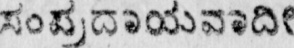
ಸಂಪ್ರದಾಯವಾದೀ
